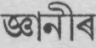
জ্ঞানীৰ
